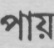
পায়
